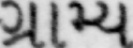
ગ્રામ્ય
